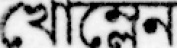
খোম্লেন
